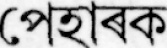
পেহাৰক
